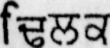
ਢਿਲਕ
